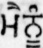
ਮੈਨੂੰ
